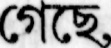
গেছে,
